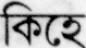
কিহে
